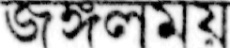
জঙ্গলময়
